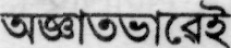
অজ্ঞাতভাৱেই
